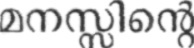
മനസ്സിന്റെ
